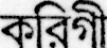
করিগী
